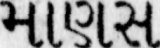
માણસ
